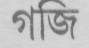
গজি
